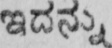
ಇದನ್ನು
